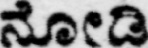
ನೋಡಿ
